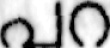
പറ
